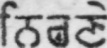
ਨਿਰਣੇ
